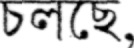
চলছে,
